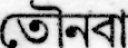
তৌনবা
